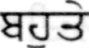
ਬਹੁਤੇ
